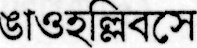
ঙাওহল্লিবসে
